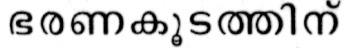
ഭരണകൂടത്തിന്
